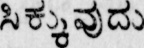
ಸಿಕ್ಕುವುದು
